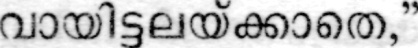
വായിട്ടലയ്ക്കാതെ,”
